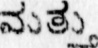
ಮತ್ತು
